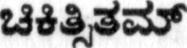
ಚಿಕಿತ್ಸಿತಮ್
